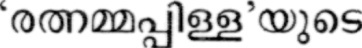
'രത്നമ്മപ്പിള്ള'യുടെ
